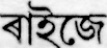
ৰাইজে
